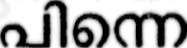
പിന്നെ
